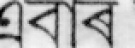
এবাৰ
